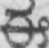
ಈ
